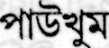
পাউখুম
